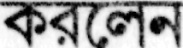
করলেন
